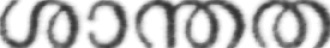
ശാന്തത
